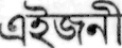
এইজনী
